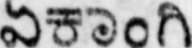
ಏಕಾಂಗಿ
